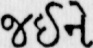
જઈને
